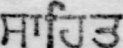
ਸਾਹਿਤ
